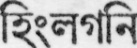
হিংলগনি
